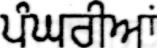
ਪੰਘਰੀਆਂ
